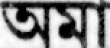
অমা
